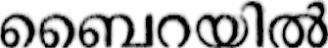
ബൈറയില്‍
